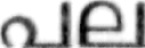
പല
